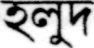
হলুদ
